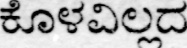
ಕೊಳವಿಲ್ಲದ
